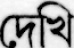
দেখি
